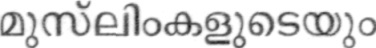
മുസ്ലിംകളുടെയും
